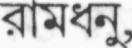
রামধনু,
